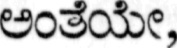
ಅಂತೆಯೇ,
